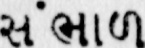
સંભાળ
